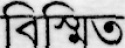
বিস্মিত
